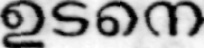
ഉടനെ
